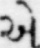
એ
